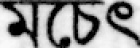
মচেৎ
